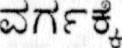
ವರ್ಗಕ್ಕೆ
